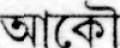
আকৌ
